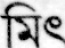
মিৎ
